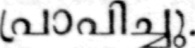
പ്രാപിച്ചു.
